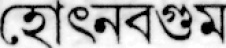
হোৎনবগুম
